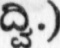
ದ್ವಿ.)
